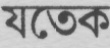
যতেক
